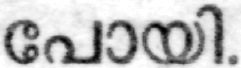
പോയി.
